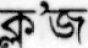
ক্ল'জ
